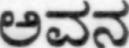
ಅವನ
